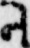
ને
